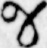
જ
